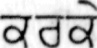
ਕਰਕੇ
